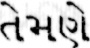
તેમણે
